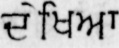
ਦੇਖਿਆ
